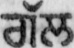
ਗੱਲ
